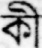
কী
